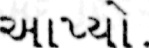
આપ્યો.
